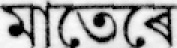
মাতেৰে
